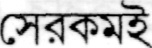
সেরকমই
